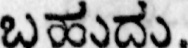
ಬಹುದು.
